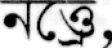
নত্ত্রে,
